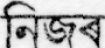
নিজৰ
